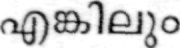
എങ്കിലും
